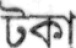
টকা
